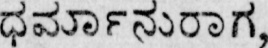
ಧರ್ಮಾನುರಾಗ,
